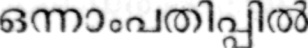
ഒന്നാംപതിപ്പില്‍
